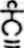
ਨੂੰ
